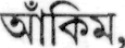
আঁকিম,
